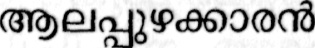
ആലപ്പുഴക്കാരന്‍
